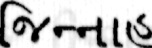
જિન્નાહ
